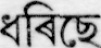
ধৰিছে
